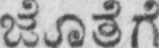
ಜೊತೆಗೆ
